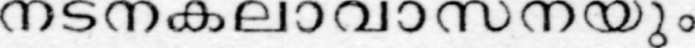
നടനകലാവാസനയും
